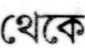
থেকে
